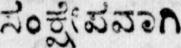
ಸಂಕ್ಷೇಪವಾಗಿ
